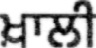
ਖ਼ਾਲੀ
